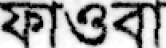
ফাওবা
